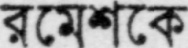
রমেশকে
